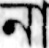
না
